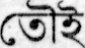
তৌই
